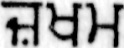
ਜ਼ਖਮ
